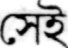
সেই
